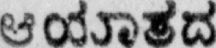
ಆಯಾತದ
